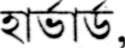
হার্ভার্ড,
